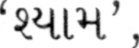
'શ્યામ',
